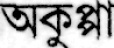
অকুপ্পা
